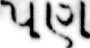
પણ
